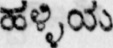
ಹಳ್ಳಿಯ
